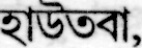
হাউতবা,
